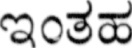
ಇಂತಹ
